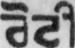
ਰੋਟੀ
